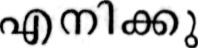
എനിക്കു
